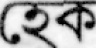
হেক
